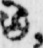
છે,
